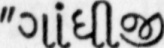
"ગાંધીજી
